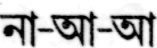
না-আ-আ
